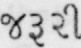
જરૂરી
